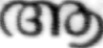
ആ
